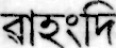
ৱাহংদি
